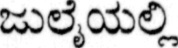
ಜುಲೈಯಲ್ಲಿ
